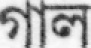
গাল
